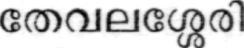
തേവലശ്ശേരി
